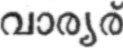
വാര്യര്
